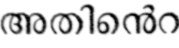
അതിന്റെ
